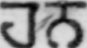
ਹਨ
